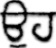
ਉਹ
